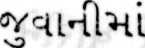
જુવાનીમાં
